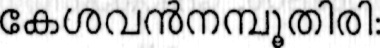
കേശവന്‍നമ്പൂതിരി:
